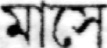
মাসে
